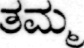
ತಮ್ಮ
